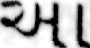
આ
